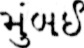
મુંબઈ
